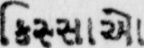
કિસ્સાઓ
